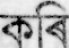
কৰি
